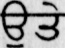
ਉਤੇ
